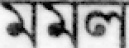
মমল
